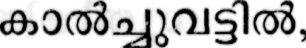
കാല്‍ച്ചുവട്ടില്‍,
